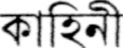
কাহিনী
